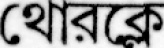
থোরক্লে
